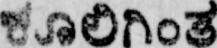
ಕೂಲಿಗಿಂತ
